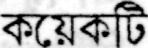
কয়েকটি
